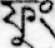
ফুং
